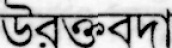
উরক্তবদা
